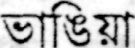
ভাঙিয়া
